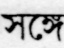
সঙ্গে
